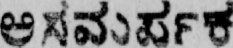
ಅಸಮರ್ಪಕ
